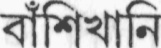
বাঁশিখানি
